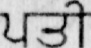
ਪਤੀ
